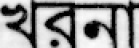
খরনা
